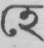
হে
